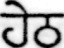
ਹੇਠ
